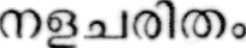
നളചരിതം
